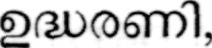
ഉദ്ധരണി,
